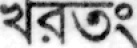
খরতং
